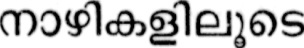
നാഴികളിലൂടെ
